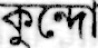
কুন্দো
